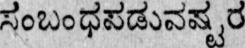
ಸಂಬಂಧಪಡುವಷ್ಟರ
